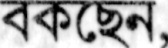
বকছেন,
